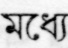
মধ্যে
